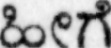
ಹೀಗೆ
